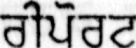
ਰੀਪੋਰਟ
